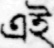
এই
